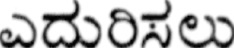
ಎದುರಿಸಲು
